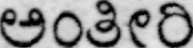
ಅಂತೀರಿ
